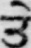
ਤੇ
